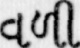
વળી
